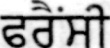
ਫਰੈਂਸੀ
